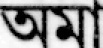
অমা
